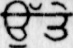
ਉੱਤੇ
